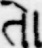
તો
